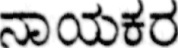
ನಾಯಕರ
